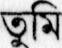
তুমি
